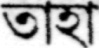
তাহা
